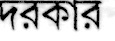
দরকার
